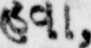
હવા,
